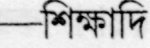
–শিক্ষাদি
